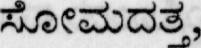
ಸೋಮದತ್ತ,
